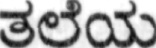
ತಲೆಯ
